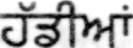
ਹੱਡੀਆਂ
